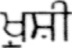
ਖ਼ੁਸ਼ੀ
